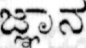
ಜ್ಞಾನ
